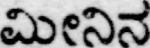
ಮೀನಿನ
